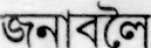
জনাবলৈ
